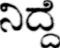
ನಿದ್ದೆ
